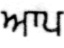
ਆਪ
